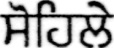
ਸੋਹਿਲੇ
